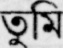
তুমি
